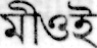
মীওই
